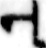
ન
